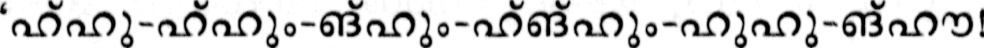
‘ഹ്ഹു-ഹ്ഹും-ങ്ഹും-ഹ്ങ്ഹും-ഹുഹു-ങ്ഹൌ!
